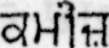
ਕਮੀਜ਼
